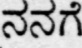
ನನಗೆ
